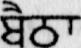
ਬੈਠਾ
